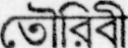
তৌরিবী
